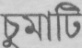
চুমাটি
